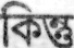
কিন্তু
